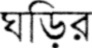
ঘড়ির
